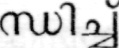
ന്ധിച്ച്
